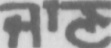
ਜਾਣ
